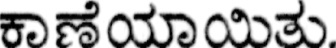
ಕಾಣೆಯಾಯಿತು.
